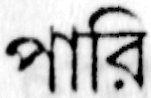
পারি
